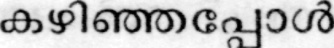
കഴിഞ്ഞപ്പോള്‍
